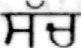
ਸੱਚ
